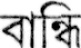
বান্ধি
